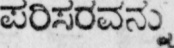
ಪರಿಸರವನ್ನು
